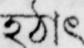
হঠাৎ
